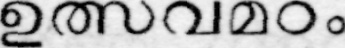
ഉത്സവമഠം
